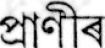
প্রাণীৰ
